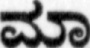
ಮಾ
